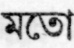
মতো
